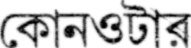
কোনওটার
